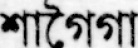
শাগৈগা
